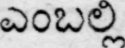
ಎಂಬಲ್ಲಿ
